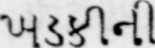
ખડકીની
